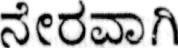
ನೇರವಾಗಿ
